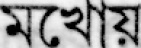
মখোয়
